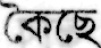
কৈছে
